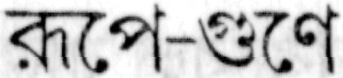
রূপে-গুণে
